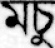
মচু
